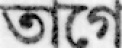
তাগে
